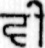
ਵੀ
